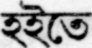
হইতে
